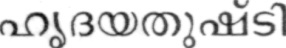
ഹൃദയതുഷ്ടി
